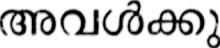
അവള്‍ക്കു
